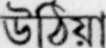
উঠিয়া
